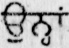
ਉਨ੍ਹਾਂ
